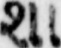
શા
